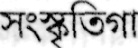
সংস্কৃতিগা
